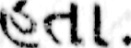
હતા.
